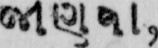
જાણવા,
